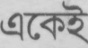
একেই
